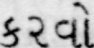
કરવો
